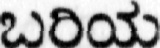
ಬರಿಯ
